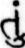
તું
